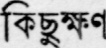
কিছুক্ষণ
